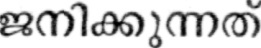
ജനിക്കുന്നത്
